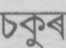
চকুৰ
